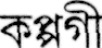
কপ্পগী
